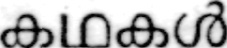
കഥകള്‍
